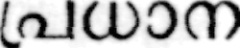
പ്രധാന
